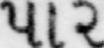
પાર
